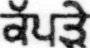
ਕੱਪੜੇ
